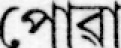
পোৱা
